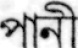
পানী
